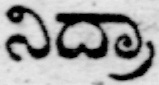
ನಿದ್ರಾ
